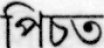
পিচত
